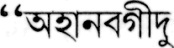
“অহানবগীদু
